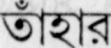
তাঁহার
